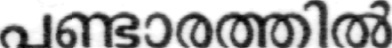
പണ്ടാരത്തില്‍
